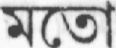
মতো
